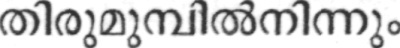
തിരുമുമ്പില്‍നിന്നും
